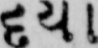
દયા
